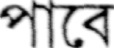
পাবে
